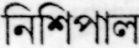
নিশিপাল
